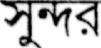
সুন্দর
